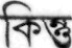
কিন্তু
